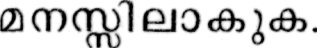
മനസ്സിലാകുക.
